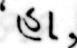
'હા,
